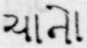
ચાનો
